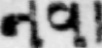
નવા
